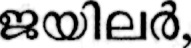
ജയിലര്‍,
